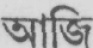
আজি
